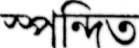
স্পন্দিত
